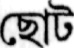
ছোট
